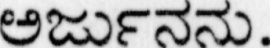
ಅರ್ಜುನನು.
